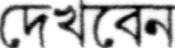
দেখবেন
